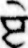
ਏ
